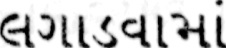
લગાડવામાં
